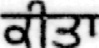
ਕੀਤਾ
